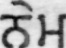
ਨੇਮ
